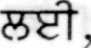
ਲਈ,
